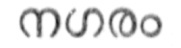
നഗരം
